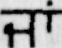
ਜਾਂ
